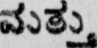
ಮತ್ತು
